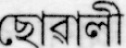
ছোৱালী
